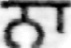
ਨਾ
